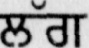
ਲੱਗ
